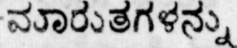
ಮಾರುತಗಳನ್ನು
